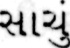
સાચું
